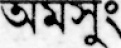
অমসুং
